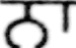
ਨਾ
